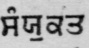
ਸੰਯੁਕਤ
